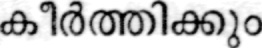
കീര്‍ത്തിക്കും
